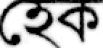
হেক
